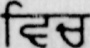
ਵਿਚ
